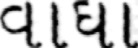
વાઘા
